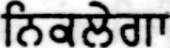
ਨਿਕਲੇਗਾ
